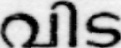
വിട
